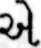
એ
